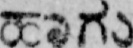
ಹಾಗು
